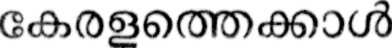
കേരളത്തെക്കാള്‍
